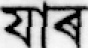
যাৰ
